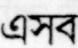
এসব
